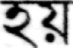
হয়
